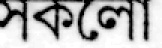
সকলো
